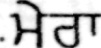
ਮੇਰਾ
